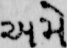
અમે
